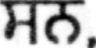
ਸਨ,
